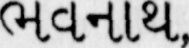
ભવનાથ,
